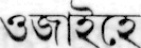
ওজাইহে
